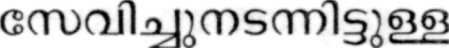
സേവിച്ചുനടന്നിട്ടുള്ള
